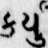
કર્યું
